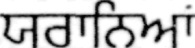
ਯਰਾਨਿਆਂ
